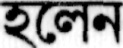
হলেন
